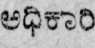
ಅಧಿಕಾರಿ
